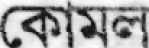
কোমল
